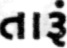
તારૂં
